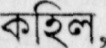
কহিল,
